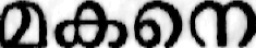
മകനെ
